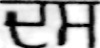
ਦਸ
